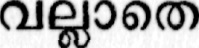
വല്ലാതെ
